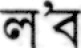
ল'ব
